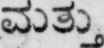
ಮತ್ತು
